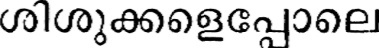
ശിശുക്കളെപ്പോലെ
